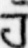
ਹੋ
